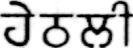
ਹੇਠਲੀ
